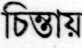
চিন্তায়
